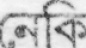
নেকি
